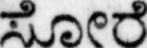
ಸೋರೆ
